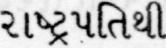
રાષ્ટ્રપતિથી
